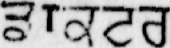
ਡਾਕਟਰ
